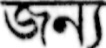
জন্য
